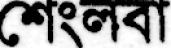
শেংলবা
